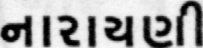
નારાયણી
